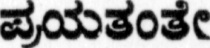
ಪ್ರಯತ೦ತೇ
